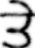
ਤੇ
